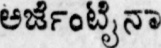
ಅರ್ಜೆಂಟೈನಾ
